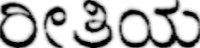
ರೀತಿಯ
